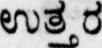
ಉತ್ತರ
